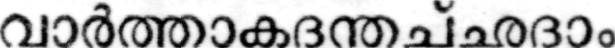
വാര്‍ത്താകദന്തച്ഛദാം
